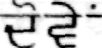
ਦੋਵੇਂ
